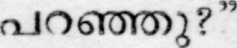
പറഞ്ഞു?''
